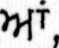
ਆਂ,
